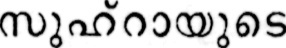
സുഹ്റായുടെ
